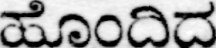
ಹೊಂದಿದ
